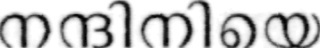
നന്ദിനിയെ
